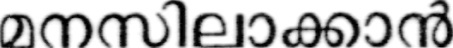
മനസിലാക്കാന്‍
